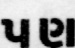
પણ
